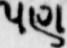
પણ
